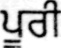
ਪੂਰੀ
